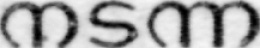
നടന്ന
